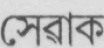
সেৱাক
